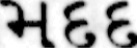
મદદ
